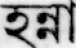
হন্না
